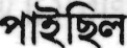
পাইছিল
